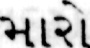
મારો
